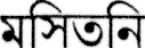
মসিতনি
